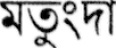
মতুংদা
